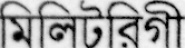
মিলিটরিগী
